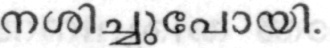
നശിച്ചുപോയി.
